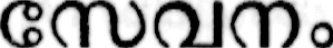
സേവനം
